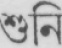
শুনি
